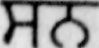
ਸਨ
